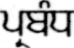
ਪ੍ਰਬੰਧ
